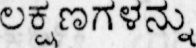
ಲಕ್ಷಣಗಳನ್ನು
